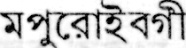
মপুরোইবগী
